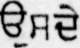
ਉਸਦੇ
